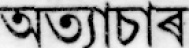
অত্যাচাৰ
